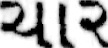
ચાર
